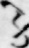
કે
